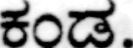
ಕಂಡ.
